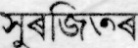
সুৰজিতৰ
